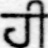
ਹੀ
